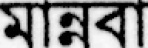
মান্নবা
